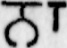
ਨਾ
